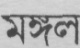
মঙ্গল
